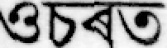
ওচৰত
